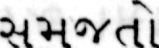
સમજતો
